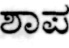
ಶಾಪ
